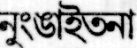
নুংঙাইতনা
